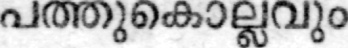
പത്തുകൊല്ലവും
